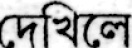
দেখিলে
